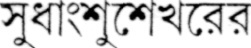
সুধাংশুশেখরের
